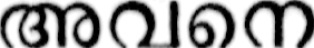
അവനെ
